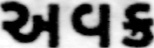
અવક્ર
